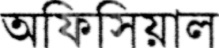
অফিসিয়াল
